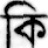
কি
